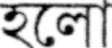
হলো
